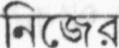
নিজের
